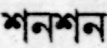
শনশন
